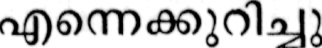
എന്നെക്കുറിച്ചു
